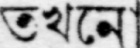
তখনো
